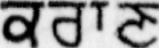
ਕਰਾਣ
